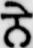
ਨੇ
